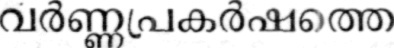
വര്‍ണ്ണപ്രകര്‍ഷത്തെ
